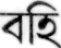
বহি
